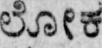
ಲೋಕ
